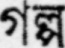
গল্প
